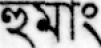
হুমাং
